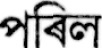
পৰিল
